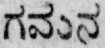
ಗಮನ
